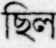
ছিল
